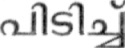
പിടിച്ച്
